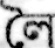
লৈ
